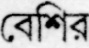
বেশির
